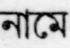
নামে
